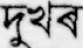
দুখৰ
